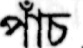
পাঁচ
